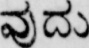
ವುದು
